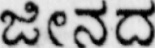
ಜೀನದ
